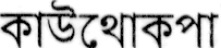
কাউথোকপা
